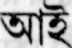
আই
